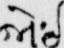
જોઈ
